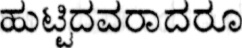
ಹುಟ್ಟಿದವರಾದರೂ
